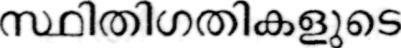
സ്ഥിതിഗതികളുടെ
